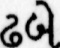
ઢબે
